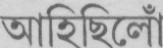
আহিছিলোঁ
